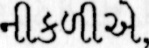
નીકળીએ,
